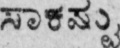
ಸಾಕಷ್ಟು
